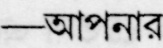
–আপনার
